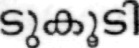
ടുകൂടി
